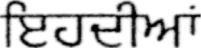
ਇਹਦੀਆਂ
